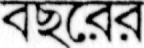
বছরের
